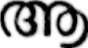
ആ
